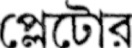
প্লেটোর
